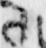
તો
